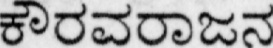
ಕೌರವರಾಜನ
